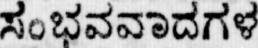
ಸಂಭವವಾದಗಳ
